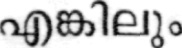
എങ്കിലും
